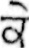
ਕੇ
